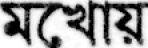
মখোয়
